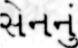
સેનનું
